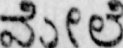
ಮೇಲೆ
